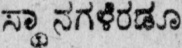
ಸ್ಥಾನಗಳೆರಡೂ
